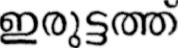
ഇരുട്ടത്ത്
